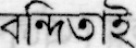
বন্দিতাই
